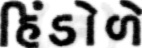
હિંડોળે
